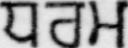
ਧਰਮ
